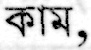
কাম,
